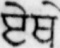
ਏਥੇ
